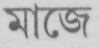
মাজে
